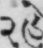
રહે
